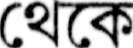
থেকে
